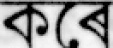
কৰে
